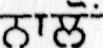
ਨਾਲੋਂ
